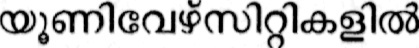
യൂണിവേഴ്സിറ്റികളില്‍
